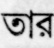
তার
